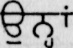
ਉਨ੍ਹਾਂ
